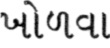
ખોળવા
